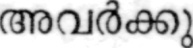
അവര്‍ക്കു
